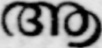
ആ
